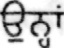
ਉਨ੍ਹਾਂ
